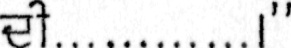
ਦੀ............।''
